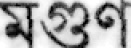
মগুণ
